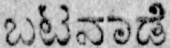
ಬಟವಾಡೆ
